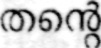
തന്റെ
